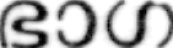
ഭാഗ
